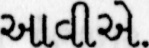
આવીએ.
